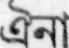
ঐনা
